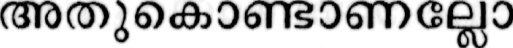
അതുകൊണ്ടാണല്ലോ
